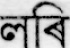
লৰি
